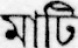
মাটি
